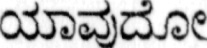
ಯಾವುದೋ
